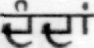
ਦੰਦਾਂ
